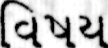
વિષય
